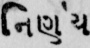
નિર્ણય
